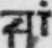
ਜਾਂ
